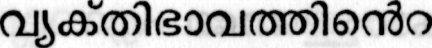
വ്യക്തിഭാവത്തിന്റെ
